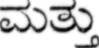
ಮತ್ತು
